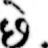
છે.
